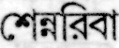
শেন্নরিবা
